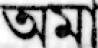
অমা
